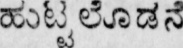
ಹುಟ್ಟಲೊಡನೆ
